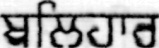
ਬਲਿਹਾਰ
